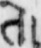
તો
